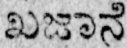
ಖಜಾನೆ
